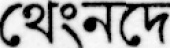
থেংনদে
